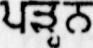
ਪੜ੍ਹਨ
